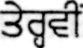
ਤੇਰ੍ਹਵੀਂ
